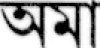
অমা
